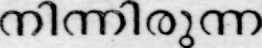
നിന്നിരുന്ന
